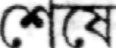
শেষে
